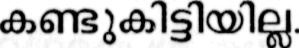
കണ്ടുകിട്ടിയില്ല.
